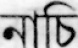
নাচি
